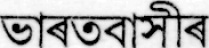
ভাৰতবাসীৰ
